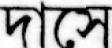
দাসে
